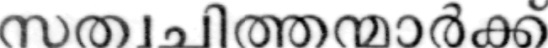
സത്വചിത്തന്മാര്‍ക്ക്
